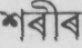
শৰীৰ
